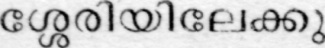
ശ്ശേരിയിലേക്കു
